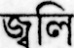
জ্বলি
